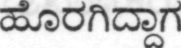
ಹೊರಗಿದ್ದಾಗ
